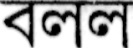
বলল
